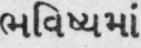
ભવિષ્યમાં
